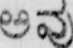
ಅವು
